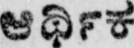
ಆರ್ಥಿಕ
